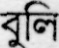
বুলি
